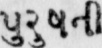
પુરુષની
